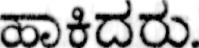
ಹಾಕಿದರು.
